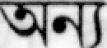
অন্য
